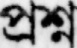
প্রশ্ন
